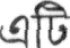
এটি
